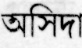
অসিদা
